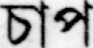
চাপ
